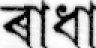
ৰাধা
